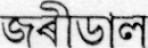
জৰীডাল
